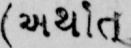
(અર્થાત્
